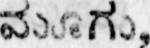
ಮೂಗು,
